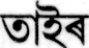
তাইৰ
